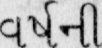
વર્ષની
